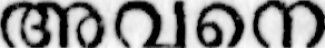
അവനെ
